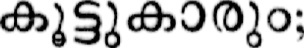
കൂട്ടുകാരും;
